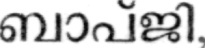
ബാപ്ജി,
